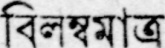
বিলম্বমাত্র
